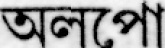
অলপো
